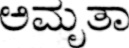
ಅಮೃತಾ
